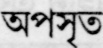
অপসৃত
